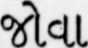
જોવા
